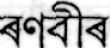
ৰণবীৰ
